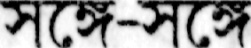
সঙ্গে-সঙ্গে
